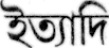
ইত্যাদি
